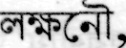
লক্ষনৌ,
